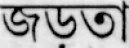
জড়তা
